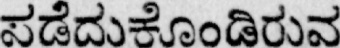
ಪಡೆದುಕೊಂಡಿರುವ
